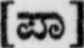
[ಪಾ]
